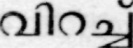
വിറച്ച്
